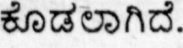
ಕೊಡಲಾಗಿದೆ.
